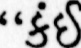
"કંઈ
